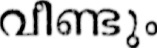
വീണ്ടും
